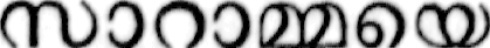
സാറാമ്മയെ
